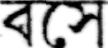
বসে
